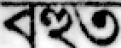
বহুত
